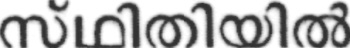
സ്ഥിതിയില്‍
